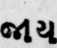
જાય
